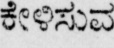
ಕೇಳಿಸುವ
